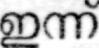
ഇന്ന്
